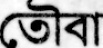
তৌবা
